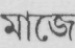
মাজে
